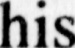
his
